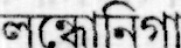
লন্ধোনিগা
